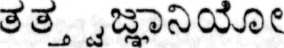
ತತ್ತ್ವಜ್ಞಾನಿಯೋ
